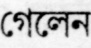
গেলেন
